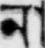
না
